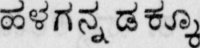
ಹಳಗನ್ನಡಕ್ಕೂ
